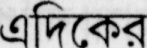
এদিকের
